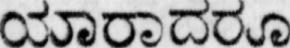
ಯಾರಾದರೂ
